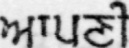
ਆਪਣੀ
